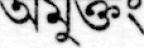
অমুক্তং
